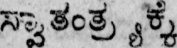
ಸ್ವಾತಂತ್ರ್ಯಕ್ಕೆ
